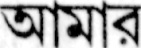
আমার
